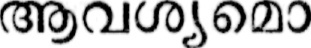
ആവശ്യമൊ
